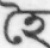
হৈ
